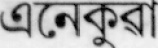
এনেকুৱা
